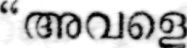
“അവളെ
